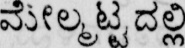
ಮೇಲ್ಮಟ್ಟದಲ್ಲಿ
